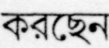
করছেন
